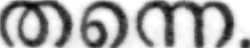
തന്നെ.
